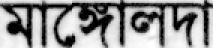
মাঙ্গোলদা
